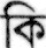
কি
